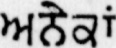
ਅਨੇਕਾਂ
